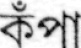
কঁপা
